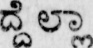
ದ್ದೆಲ್ಲಾ
